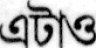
এটাও
